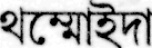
থম্মোইদা
